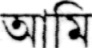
আমি
